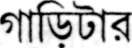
গাড়িটার
